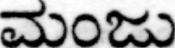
ಮಂಜು
